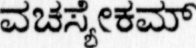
ವಚಸ್ಯೇಕಮ್
